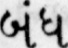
બંધ
